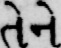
તેને
